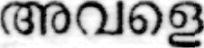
അവളെ
